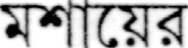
মশায়ের
